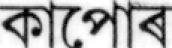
কাপোৰ
